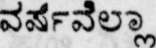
ವರ್ಷವೆಲ್ಲಾ
